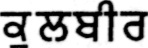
ਕੁਲਬੀਰ
